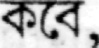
কবে,
